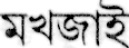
মখজাই
